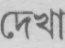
দেখা
